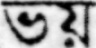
ভয়
